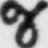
જ
